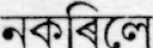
নকৰিলে
